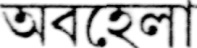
অবহেলা
